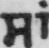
ਸਾ
